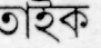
তাইক
